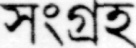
সংগ্রহ
